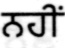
ਨਹੀਂ
